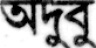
অদুবু
